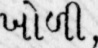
ખોળી,
